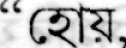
“হোয়,
